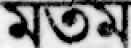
মতম
